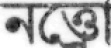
নও্রো
